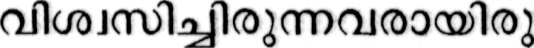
വിശ്വസിച്ചിരുന്നവരായിരു
